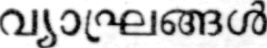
വ്യാഘ്രങ്ങള്‍
